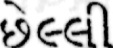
છેલ્લી
